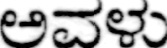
ಅವಳು
